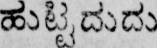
ಹುಟ್ಟಿದುದು
